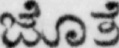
ಜೊತೆ
